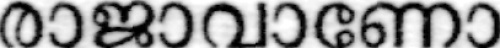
രാജാവാണോ
